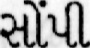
સોંપી
